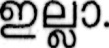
ഇല്ലാ.
